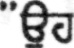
''ਉਹ
